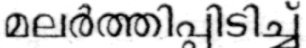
മലര്‍ത്തിപ്പിടിച്ച്
